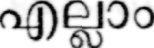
എല്ലാം
